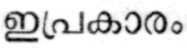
ഇപ്രകാരം
